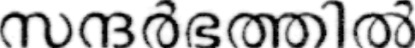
സന്ദര്‍ഭത്തില്‍
